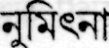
নুমিৎনা
